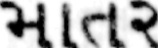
માતર
